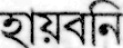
হায়বনি
